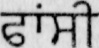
ਫਾਂਸੀ
